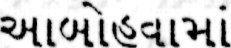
આબોહવામાં
